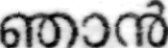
ഞാന്‍
